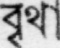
বৃথা
